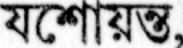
যশোয়ন্ত,
